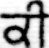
ਕੀ
